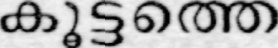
കൂട്ടത്തെ
